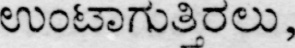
ಉಂಟಾಗುತ್ತಿರಲು,
